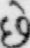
છે
